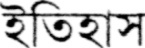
ইতিহাস
